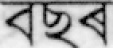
বছৰ
